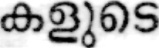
കളുടെ
